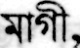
মাগী,
